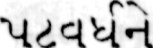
પટવર્ધને
